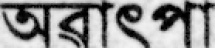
অৱাৎপা
